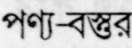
পণ্য-বস্তুর
